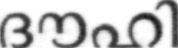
ദൌഹി
